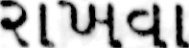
રાખવા
